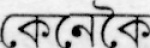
কেনেকৈ
